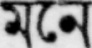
মনে
